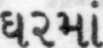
ઘરમાં
